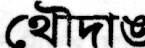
থৌদাঙ
